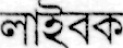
লাইবক
